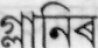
গ্লানিৰ
